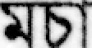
মচা
